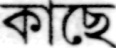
কাছে
